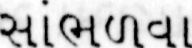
સાંભળવા
